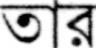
তার
